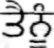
ਤੈਨੂੰ
